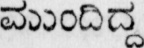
ಮುಂದಿದ್ದ
